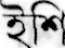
ইশি
